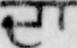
ਦਾ
